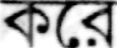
করে
